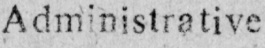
Administrative
